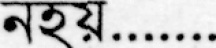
নহয়.......
